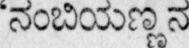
‘ನಂಬಿಯಣ್ಣನ
